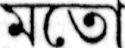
মতো
